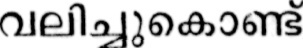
വലിച്ചുകൊണ്ട്
